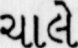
ચાલે
